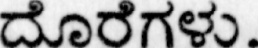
ದೊರೆಗಳು.
